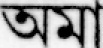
অমা
